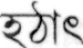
হঠাৎ
